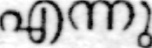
എന്നു
